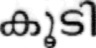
കൂടി
